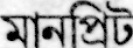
মানপ্রিট
